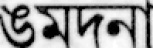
ঙমদনা
